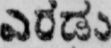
ಎರಡು
